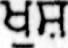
ਖੁਸ਼
